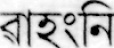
ৱাহংনি
